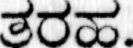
ತರಹ.
